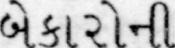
બેકારોની
